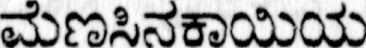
ಮೆಣಸಿನಕಾಯಿಯ
